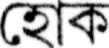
হোক
